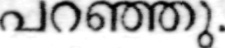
പറഞ്ഞു.
